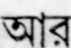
আর
